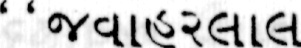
"જવાહરલાલ
